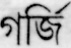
গর্জি
